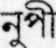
নুপী
